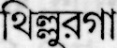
থিল্লুরগা
